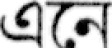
এনে
